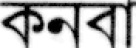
কনবা
